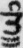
ਤੂੰ
